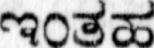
ಇಂತಹ
